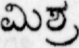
ಮಿಶ್ರ
